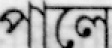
পালে
